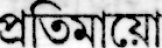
প্রতিমায়ো
